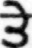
ਤੇ
